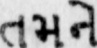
તમને
